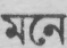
মনে
